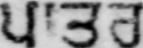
ਪਾਤਰ
